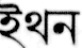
ইথন
